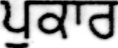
ਪੁਕਾਰ
